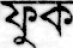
ফুক
